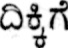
ದಿಕ್ಕಿಗೆ
